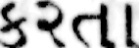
કરતા
